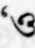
‘ও
